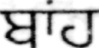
ਬਾਂਹ
